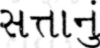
સત્તાનું
